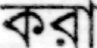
করা
